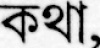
কথা,
